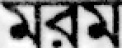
মরম
